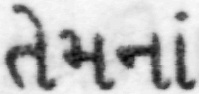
તેમનાં
